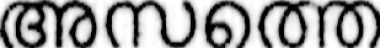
അസത്തെ
